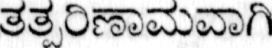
ತತ್ಪರಿಣಾಮವಾಗಿ
